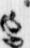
હું
